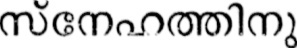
സ്നേഹത്തിനു
